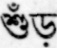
শুঁড়
